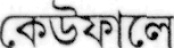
কেউফালে
